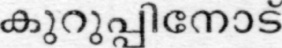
കുറുപ്പിനോട്
